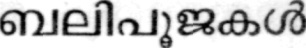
ബലിപൂജകള്‍
